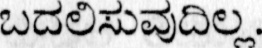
ಬದಲಿಸುವುದಿಲ್ಲ.
